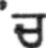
'ਚ
